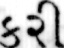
કરી
